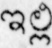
ಇಲ್ಲಿ
